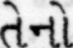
તેનો
